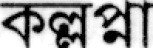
কল্লপ্না
